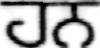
ਹਨ
